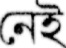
নেই
